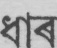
ধাৰ
